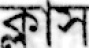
ক্লাস
